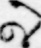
જે
